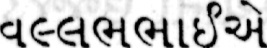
વલ્લભભાઈએ
